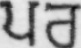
ਪਰ
